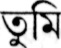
তুমি
